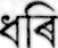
ধৰি
